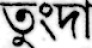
তুংদা
